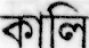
কালি
